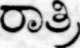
ರಾತ್ರಿ
